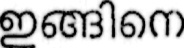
ഇങ്ങിനെ
